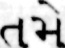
તમે
